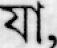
যা,
